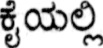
ಕೈಯಲ್ಲಿ
